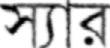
স্যার
